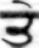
ਤੇ
